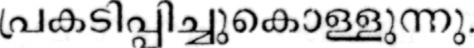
പ്രകടിപ്പിച്ചുകൊള്ളുന്നു.
